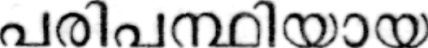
പരിപന്ഥിയായ
